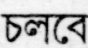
চলবে
